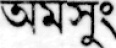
অমসুং
